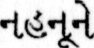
નહનૂને
